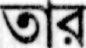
তার
